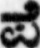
ಪೆ
